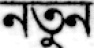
নতুন
